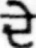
ਦੇ
